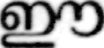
ഈ
